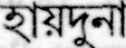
হায়দুনা
